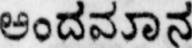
ಅಂದಮಾನ
